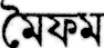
মৈফম
